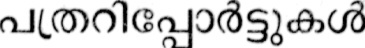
പത്രറിപ്പോര്‍ട്ടുകള്‍
